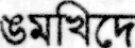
ঙমখিদে
